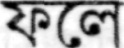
ফলে
